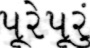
પૂરેપૂરું
